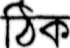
ঠিক
